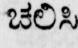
ಚಲಿಸಿ
